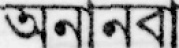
অনানবা
